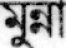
মুন্না
